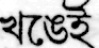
খঙেই
